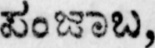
ಪಂಜಾಬ,
